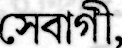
সেবাগী,
